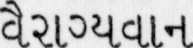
વૈરાગ્યવાન
